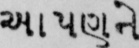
આપણને
